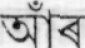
আঁৰ
